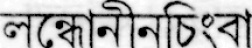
লন্ধোনীনচিংবা
